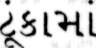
ટૂંકામા
